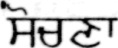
ਸੋਚਣਾ
